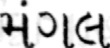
મંગલ
